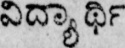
ವಿದ್ಯಾರ್ಥಿ
